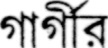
গার্গীর
